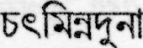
চৎমিন্নদুনা
